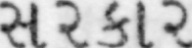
સરકાર
